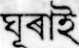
ঘূৰাই
